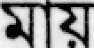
মায়
